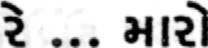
રે......મારો
